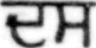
ਦਸ
